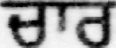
ਚਾਰ
